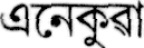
এনেকুৱা
